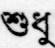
শুধু
